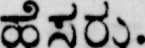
ಹೆಸರು.
